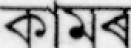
কামৰ
